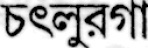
চৎলুরগা
